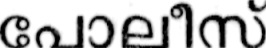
പോലീസ്
